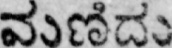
ಮಣಿದು
